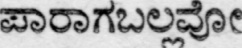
ಪಾರಾಗಬಲ್ಲವೋ
